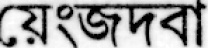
য়েংজদবা
